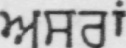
ਅਸਰਾਂ
